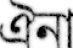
ঐনা
